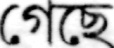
গেছে
